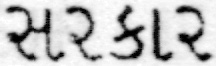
સરકાર
